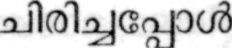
ചിരിച്ചപ്പോള്‍
